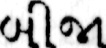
બીજા
